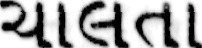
ચાલતા
